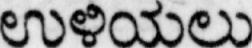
ಉಳಿಯಲು
